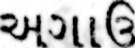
અગાઉ
